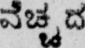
ವೆಚ್ಚದ
